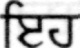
ਇਹ
